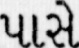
પાસે
